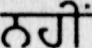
ਨਹੀਂ
